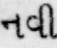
નવી
